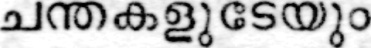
ചന്തകളുടേയും
